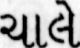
ચાલે
